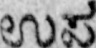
ಉಪ
